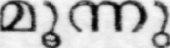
മൂന്നു
